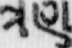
ત્રણ
